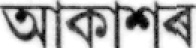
আকাশৰ
